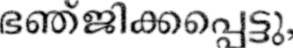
ഭഞ്ജിക്കപ്പെട്ടു,
